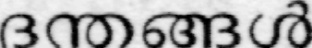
ദന്തങ്ങള്‍
